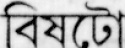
বিষটো
